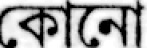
কোনো
